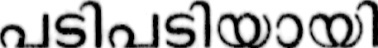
പടിപടിയായി
